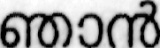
ഞാന്‍
